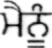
ਮੈਨੂੰ
